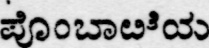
ಪೊಂಬಾೞೆಯ
